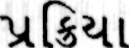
પ્રક્રિયા
